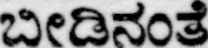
ಬೀಡಿನಂತೆ
